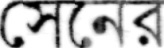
সেনের
